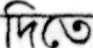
দিতে
